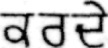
ਕਰਦੇ
